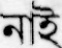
নাই
